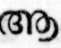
ആ
